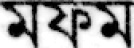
মফম
